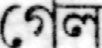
গেল
